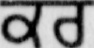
ਕਰ
